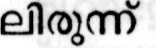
ലിരുന്ന്
